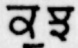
ਕੁਝ
